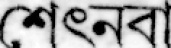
শেৎনবা
